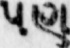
પણ
